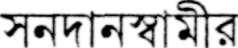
সনদানস্বামীর
